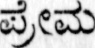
ಪ್ರೇಮ
